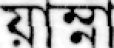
য়াম্না
